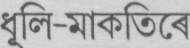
ধূলি-মাকতিৰে
